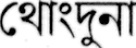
থোংদুনা
